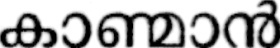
കാണ്മാന്‍
